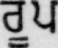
ਰੂਪ
